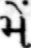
મેં
